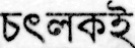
চৎলকই
